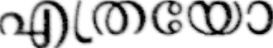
എത്രയോ
